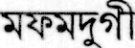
মফমদুগী
